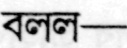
বলল–
